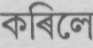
কৰিলে
